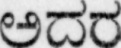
ಅದರ
